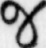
જ
